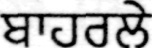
ਬਾਹਰਲੇ
